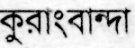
কুরাংবান্দা
